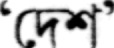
‘দেশ’
